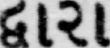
દ્વારા
